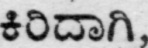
ಕಿರಿದಾಗಿ,
